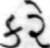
કરે
